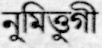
নুমিত্তুগী
